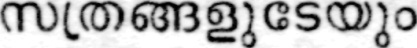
സത്രങ്ങളുടേയും
